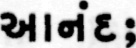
આનંદ
